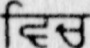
ਵਿਚ
